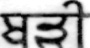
ਬੜੀ
